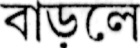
বাড়লে
